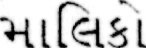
માલિકો
